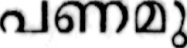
പണമു
